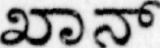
ಖಾನ್
